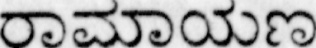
ರಾಮಾಯಣ
